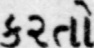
કરતો
